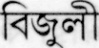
বিজুলী
